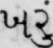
ખરું
